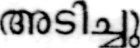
അടിച്ചു
